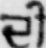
ਦੀ
